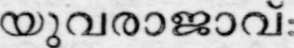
യുവരാജാവ്:
